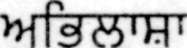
ਅਭਿਲਾਸ਼ਾ
